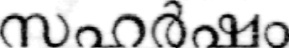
സഹര്‍ഷം
